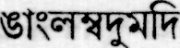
ঙাংলম্বদুমদি
